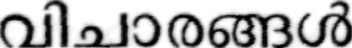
വിചാരങ്ങള്‍
